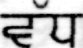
ਵੱਧ
